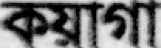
কয়াগা
